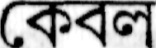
কেবল
